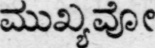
ಮುಖ್ಯವೋ
